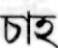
চাহ
